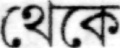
থেকে
